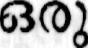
ഒരു
